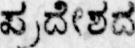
ಪ್ರದೇಶದ
